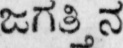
ಜಗತ್ತಿನ
